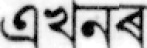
এখনৰ
